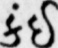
કંઈ
